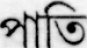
পাতি
